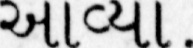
આવ્યા.
